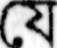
যে
